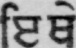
ਇਥੇ
